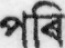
পৰি
